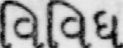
વિવિધ
